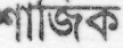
শজিক
